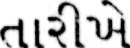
તારીખે
